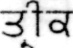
ਤ੍ਰੀਕ
